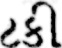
ટકી
